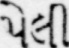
પેલી
